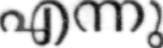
എന്നു
